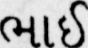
ભાઈ
